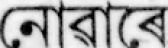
নোৱাৰে
